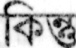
কিন্তু
